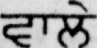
ਵਾਲੇ
